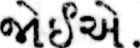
જોઈએ.
